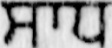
ਸਾਧ
